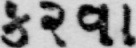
કરવા
